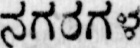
ನಗರಗಳ
